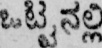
ಒಟ್ಟಿನಲ್ಲಿ
